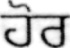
ਹੋਰ
